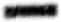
ಕಣಾದ
